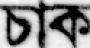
চাক
